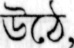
উঠে,
